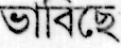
ভাবিছে
